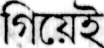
গিয়েই
